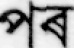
পৰ
